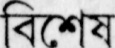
বিশেষ
